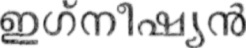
ഇഗ്നീഷ്യന്‍
